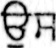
ਉਸ
